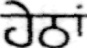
ਹੇਠਾਂ
